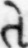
તે
